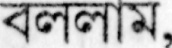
বললাম,
